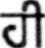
ਹੀ
